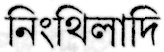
নিংথিলাদি
